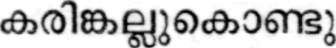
കരിങ്കല്ലുകൊണ്ടു
